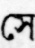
সে
